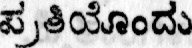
ಪ್ರತಿಯೊಂದು
